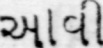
આવી
